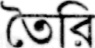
তৈরি
